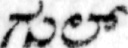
ಗುಲ್
